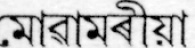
মোৱামৰীয়া
